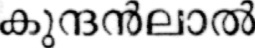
കുന്ദന്‍ലാല്‍
